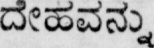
ದೇಹವನ್ನು
